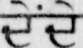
ਦੇਂਦੇ
